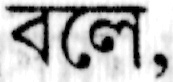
বলে,
